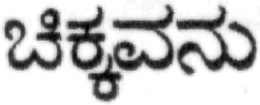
ಚಿಕ್ಕವನು
